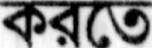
করতে
